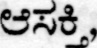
ಆಸಕ್ತಿ,
